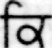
ਕਿ
